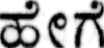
ಹೇಗೆ
